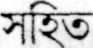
সহিত
